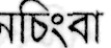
নচিংবা
